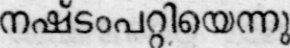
നഷ്ടംപറ്റിയെന്നു
